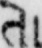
તો
